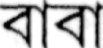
বাবা
